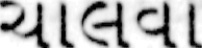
ચાલવા
